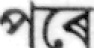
পৰে
